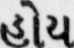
હોય
